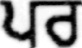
ਪਰ
